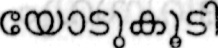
യോടുകൂടി
